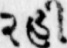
રહી
